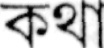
কথা
